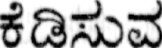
ಕೆಡಿಸುವ
